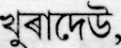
খুৰাদেউ,
